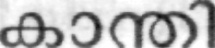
കാന്തി
